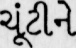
ચૂંટીને
